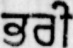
ਭਰੀ
